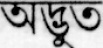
অদ্ভুত
